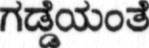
ಗಡ್ಡೆಯಂತೆ
